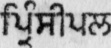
ਪ੍ਰਿੰਸੀਪਲ
